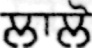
ਲਾਲੋ
